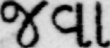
જવા
